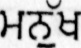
ਮਨੁੱਖ
